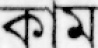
কাম
